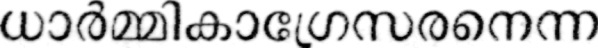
ധാര്‍മ്മികാഗ്രേസരനെന്ന
